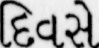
દિવસે
